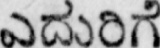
ಎದುರಿಗೆ
